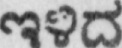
ಇಳಿದ
